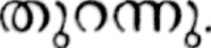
തുറന്നു.
